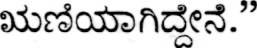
ಋಣಿಯಾಗಿದ್ದೇನೆ."
